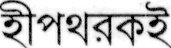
হীপথরকই
